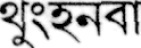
থুংহনবা
